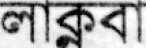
লাক্নবা
